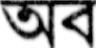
অব
